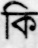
কি
